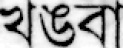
খঙবা
